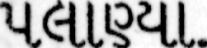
પલાણ્યા.
